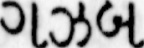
ગઝબ
